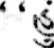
"હું
